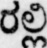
ರಲ್ಲಿ
